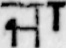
ਜਾ
